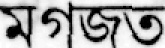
মগজত
